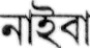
নাইবা
